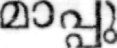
മാപ്പു
